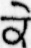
ਕੇ
